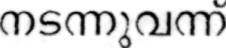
നടന്നുവന്ന്
